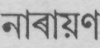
নাৰায়ণ
